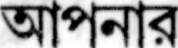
আপনার
